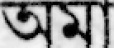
অমা
